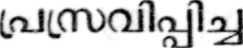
പ്രസ്രവിപ്പിച്ച
